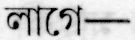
লাগে-
